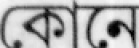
কোনে
